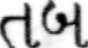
તબ
